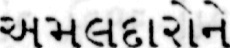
અમલદારોને
